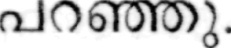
പറഞ്ഞു.
